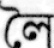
লৈ
